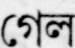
গেল
